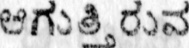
ಆಗುತ್ತಿರುವ
